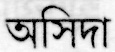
অসিদা
